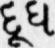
દૂધ
